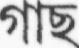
গাছ
